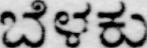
ಬೆಳಕು
